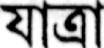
যাত্রা
